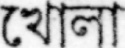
খোলা
